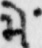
મેં
